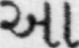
આ
